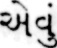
એવું
